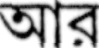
আর
